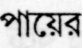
পায়ের
